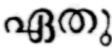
ഏതു
